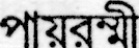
পায়রম্মী
